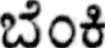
ಬೆಂಕಿ
